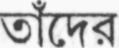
তাঁদের
